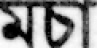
মচা
